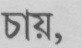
চায়,
